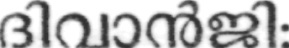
ദിവാന്‍ജി:
